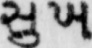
સુખ
